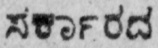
ಸರ್ಕಾರದ
